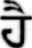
ਹੈ
